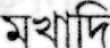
মখাদি
